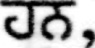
ਹਨ,
